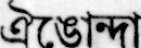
ঐঙোন্দা
